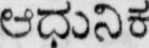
ಆಧುನಿಕ
